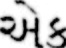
એક
